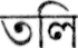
তলি
